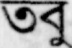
তবু
